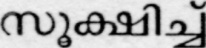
സൂക്ഷിച്ച്
